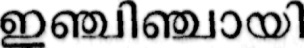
ഇഞ്ചിഞ്ചായി
